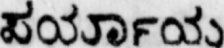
ಪರ್ಯಾಯ
